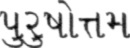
પુરુષોત્તમ
